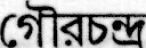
গৌরচন্দ্র
